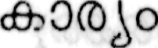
കാര്യം
